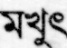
মখুৎ
